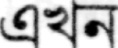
এখন
